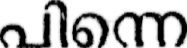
പിന്നെ
